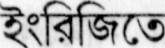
ইংরিজিতে
